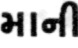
માની
